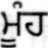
ਮੂੰਹ
